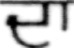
ਦਾ
